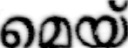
മെയ്
